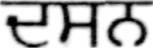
ਦਸਨ
